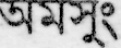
অমসুং
